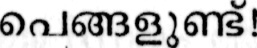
പെങ്ങളുണ്ട്!
